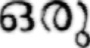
ഒരു
